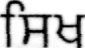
ਸਿਖ
